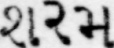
શરમ
